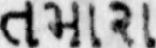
તમારા
